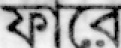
ফারে
